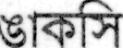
ঙাকসি
